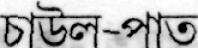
চাউল-পাত
